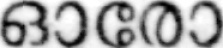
ഓരോ
